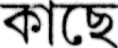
কাছে
